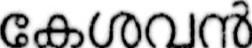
കേശവന്‍
